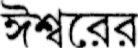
ঈশ্বরের
